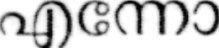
എന്നോ
